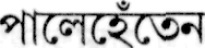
পালেহেঁতেন
